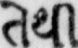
તેથી
